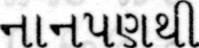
નાનપણથી
